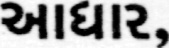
આધાર,
